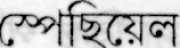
স্পেছিয়েল
